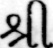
શ્રી
